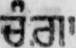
ਚੰਗਾ
